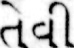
તેવી
